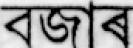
বজাৰ
